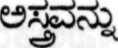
ಅಸ್ತ್ರವನ್ನು
